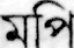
মপি
